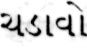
ચડાવો
